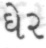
ઘેર
